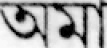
অমা
